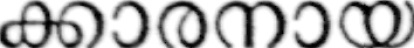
ക്കാരനായ
